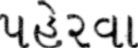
પહેરવા
